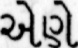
એણે
